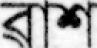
ৱাশ
